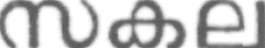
സകല
